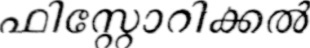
ഫിസ്റ്റോറിക്കല്‍
